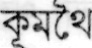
কূমথৈ
